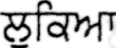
ਲੁਕਿਆ
